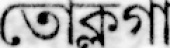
তোক্লগা
